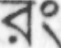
রং
